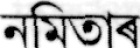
নমিতাৰ
